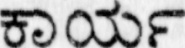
ಕಾರ್ಯ
